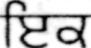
ਇਕ
